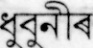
ধুবুনীৰ
